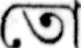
তো
